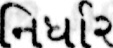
નિર્ધાર
